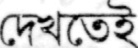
দেখতেই
